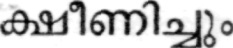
ക്ഷീണിച്ചും
